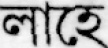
লাহে
